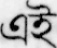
এই
